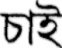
চাই
